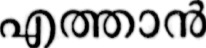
എത്താന്‍
